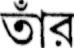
তাঁর
